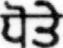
ਧੋਤੇ
